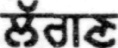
ਲੱਗਣ
